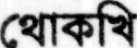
থোকখি
